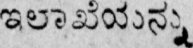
ಇಲಾಖೆಯನ್ನು
